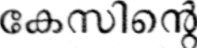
കേസിന്റെ
